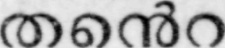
തന്റെ
